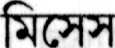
মিসেস
